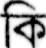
কি
